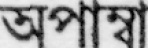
অপাম্বা
